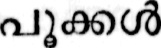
പൂക്കള്‍
